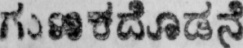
ಗುಣಕದೊಡನೆ
